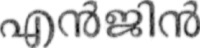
എന്‍ജിന്‍
